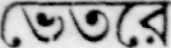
ভেতরে
